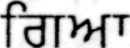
ਗਿਆ
